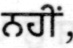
ਨਹੀਂ,
